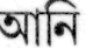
আনি
